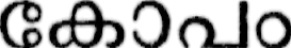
കോപം
